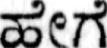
ಹೇಗೆ
